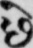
છે
